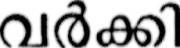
വര്‍ക്കി
